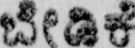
ಬೇಡಿಕೆ
